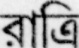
রাত্রি
